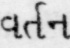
વર્તન
